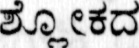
ಶ್ಲೋಕದ
